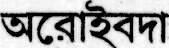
অরোইবদা
